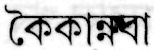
কৈকান্নবা
